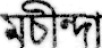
মচীন্দা
